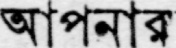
আপনার
